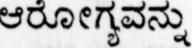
ಆರೋಗ್ಯವನ್ನು
